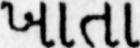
ખાતા
